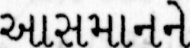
આસમાનને
